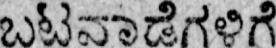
ಬಟವಾಡೆಗಳಿಗೆ
